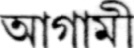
আগামী
